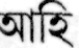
আহি
